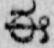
ಈ
